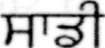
ਸਾਡੀ
